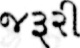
જરૂરી
